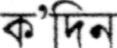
ক’দিন
